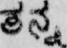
ತನ್ನ
